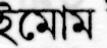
ইমোম
